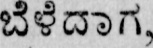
ಬೆಳೆದಾಗ,
